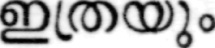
ഇത്രയും
